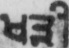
ਖੜੀ
